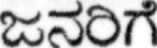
ಜನರಿಗೆ
